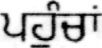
ਪਹੁੰਚਾਂ
